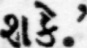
શકે.'
